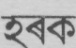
হৰক
